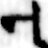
ન
